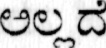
ಅಲ್ಲದೆ
